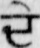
ਦੇ
